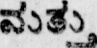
ಮತ್ತು
